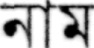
নাম
